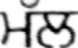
ਮੱਲ
